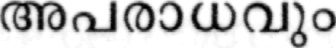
അപരാധവും
